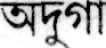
অদুগা
